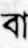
বা
